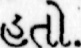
હતો.
